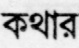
কথার
